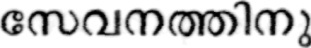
സേവനത്തിനു
